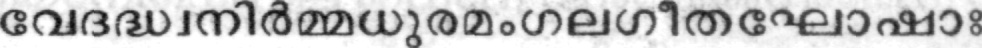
വേദദ്ധ്വനിര്‍മ്മധുരമംഗലഗീതഘോഷാഃ
